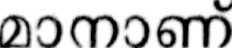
മാനാണ്.
